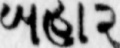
બહાર
